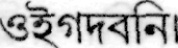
ওইগদবনি।
